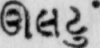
ઊલટું
